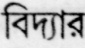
বিদ্যার
